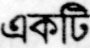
একটি
